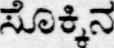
ಸೊಕ್ಕಿನ
